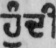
ਹੁੰਦੀ
